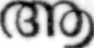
ആ
